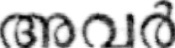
അവര്‍
